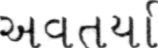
અવતર્યા
